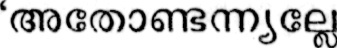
‘അതോണ്ടന്ന്യല്ലേ
